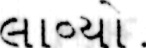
લાવ્યો.
